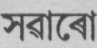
সৱাৰো
